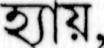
হ্যায়,
